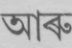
আৰু
